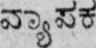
ವ್ಯಾಪಕ
